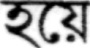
হয়ে
